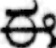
ಈ
